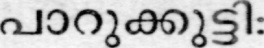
പാറുക്കുട്ടി:
